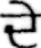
ਦੇ
